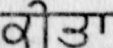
ਕੀਤਾ
